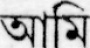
আমি
